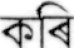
কৰি
